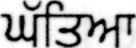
ਘੱਤਿਆ
